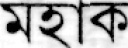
মহাক
